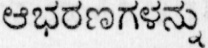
ಆಭರಣಗಳನ್ನು
